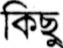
কিছু
